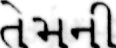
તેમની
